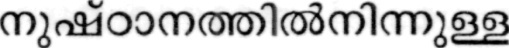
നുഷ്ഠാനത്തില്‍നിന്നുള്ള
